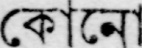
কোনো
